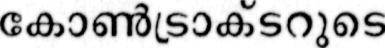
കോണ്‍ട്രാക്ടറുടെ
